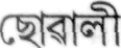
ছোৱালী
